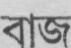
বাজ
